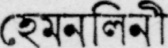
হেমনলিনী
